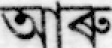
আৰু
